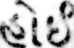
હોઈ
